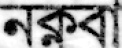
নক্নবা
